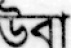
ঊবা
